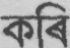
কৰি
